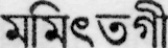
মমিৎতগী
